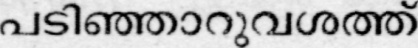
പടിഞ്ഞാറുവശത്ത്
